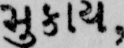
મુકાય,
